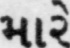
મારે
